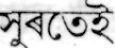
সুৰতেই
